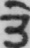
ਤੇ
